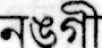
নঙগী
